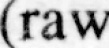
(raw
